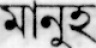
মানুহ
